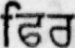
ਫਿਰ
